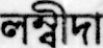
লম্বীদা
